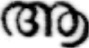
ആ
